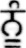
ਨੂੰ
